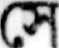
সে
